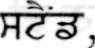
ਸਟੈਂਡ,
